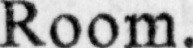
Room
